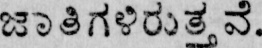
ಜಾತಿಗಳಿರುತ್ತವೆ.
